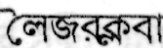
লৈজরক্লবা
